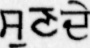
ਸੁਣਦੇ
